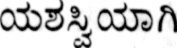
ಯಶಸ್ವಿಯಾಗಿ
